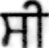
ਸੀ
